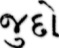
જુદો
